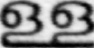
ള്ള
